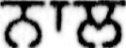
ਨਾਲ
